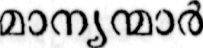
മാന്യന്മാര്‍
